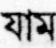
যাম
